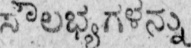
ಸೌಲಭ್ಯಗಳನ್ನು
